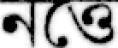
নত্তে
